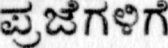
ಪ್ರಜೆಗಳಿಗೆ
